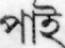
পাই
